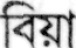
বিয়া
